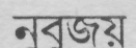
নুবুজয়
